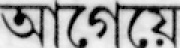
আগেয়ে
